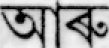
আৰু
